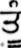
ਤੂੰ
